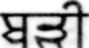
ਬੜੀ
